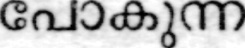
പോകുന്ന
